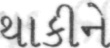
થાકીને
